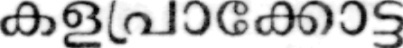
കളപ്രാക്കോട്ട
